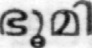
ഭൂമി
